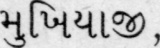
મુખિયાજી,
